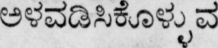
ಅಳವಡಿಸಿಕೊಳ್ಳುವ
